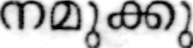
നമുക്കു
